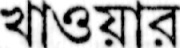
খাওয়ার
